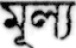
মূল্য
